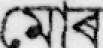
মোৰ
